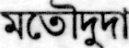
মতৌদুদা
